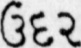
ઉંદર
